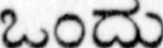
ಒಂದು
